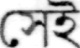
সেই
